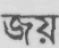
জয়
